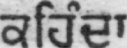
ਕਹਿੰਦਾ
